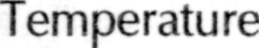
Temperature
